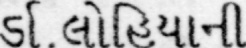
ર્ડા.લોહિયાની
